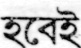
হবেই
